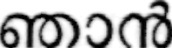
ഞാന്‍
